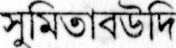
সুমিতাবউদি
